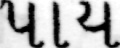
પાય
